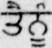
ਤੈਨੂੰ
